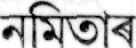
নমিতাৰ
